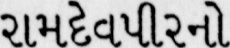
રામદેવપીરનો
